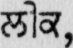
ਲੀਕ,
